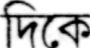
দিকে
